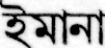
ইমানা
